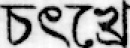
চৎখ্রে
